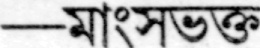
-মাংসভক্ত
